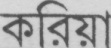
করিয়া
